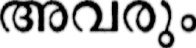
അവരും
